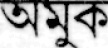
অমুক
